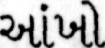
આંખો
